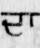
ਦਾ
